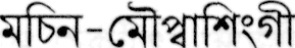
মচিন-মৌপ্বাশিংগী
